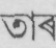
তাৰ
